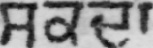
ਸਕਦਾ
